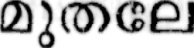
മുതലേ
